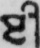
ਈ
